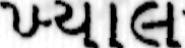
ખ્યાલ
